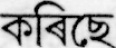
কৰিছে
